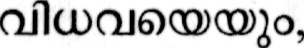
വിധവയെയും,
